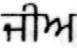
ਜੀਅ
